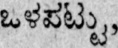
ಒಳಪಟ್ಟು,
